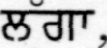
ਲੱਗਾ,
